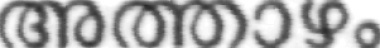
അത്താഴം
